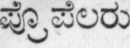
ಪ್ರೊಪೆಲರು
